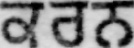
ਕਰਨ
